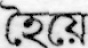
হৈয়ে
